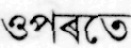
ওপৰতে
